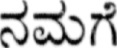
ನಮಗೆ
